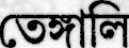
তেঙ্গালি
